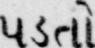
પડતો
